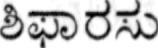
ಶಿಫಾರಸು
